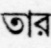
তার
